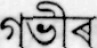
গভীৰ
